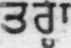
ਤਰ੍ਹਾ
